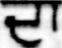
ਦਾ
